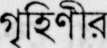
গৃহিণীর
